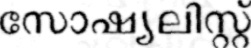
സോഷ്യലിസ്റ്റ്
